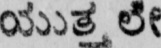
ಯುತ್ತಲೇ
